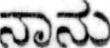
ನಾನು
